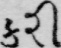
કરી
